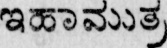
ಇಹಾಮುತ್ರ
